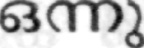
ഒന്നു
